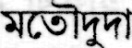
মতৌদুদা
